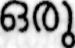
ഒരു
